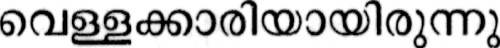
വെള്ളക്കാരിയായിരുന്നു
